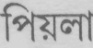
পিয়লা
